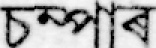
চম্পাৰ
